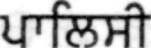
ਪਾਲਿਸੀ
